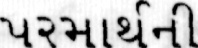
પરમાર્થની
